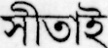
সীতাই
